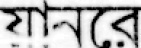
য়ানরে
